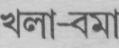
খলা-বমা
